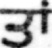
ਤਾਂ
